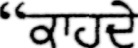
''ਕਾਹਦੇ
